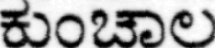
ಕುಂಚಾಲ
